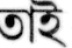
তাই
